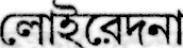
লোইরেদনা
